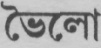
ভৈলো
